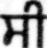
ਸੀ
